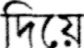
দিয়ে
